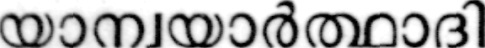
യാന്വയാര്‍ത്ഥാദി
